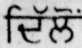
ਦਿੱਲੋਂ
